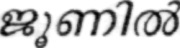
ജൂണില്‍
